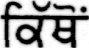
ਕਿੱਥੋਂ
